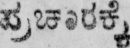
ಪ್ರಚಾರಕ್ಕೆ
